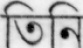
তিনি
